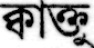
ক্বাক্তু
